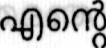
എന്റെ
